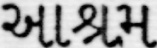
આશ્રમ
